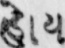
હોય
